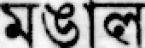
মঙাল
